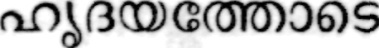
ഹൃദയത്തോടെ
